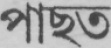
পাছত
